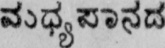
ಮಧ್ಯಪಾನದ
